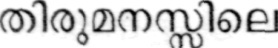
തിരുമനസ്സിലെ
